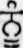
ਨੂੰ
